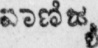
ವಾಣಿಜ್ಯ
